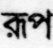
রূপ
